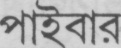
পাইবার
